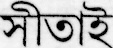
সীতাই
